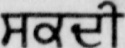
ਸਕਦੀ
